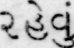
રહેવું
